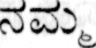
ನಮ್ಮ
